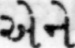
એને
